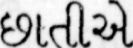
છાતીએ
